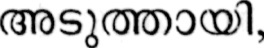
അടുത്തായി,
